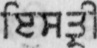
ਇਸਤ੍ਰੀ
